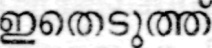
ഇതെടുത്ത്
